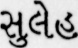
સુલેહ
